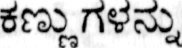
ಕಣ್ಣುಗಳನ್ನು
